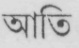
আতি
